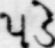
પડે
